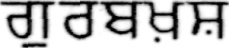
ਗੁਰਬਖ਼ਸ਼
